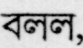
বলল,
